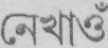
নেখাওঁ
